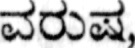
ವರುಷ,
